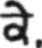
ਕੇ,
